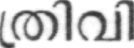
ത്രിവി
